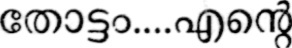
തോട്ടം...എന്റെ
